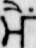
ਮੈਂ
